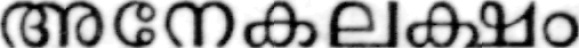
അനേകലക്ഷം
